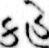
કહે
